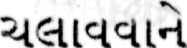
ચલાવવાને
